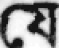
যে
